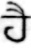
ਹੈ
